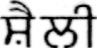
ਸ਼ੈਲੀ
